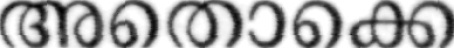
അതൊക്കെ
